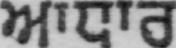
ਆਧਾਰ
